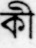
কী
